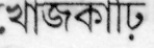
খোজকাঢ়ি
